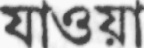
যাওয়া
